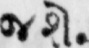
જશે.
